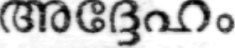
അദ്ദേഹം
